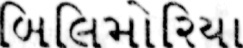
બિલિમોરિયા
